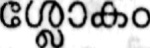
ശ്ലോകം
